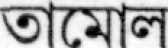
তামোল
